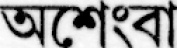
অশেংবা
